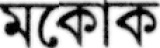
মকোক
